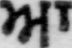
ਆ
